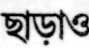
ছাড়াও
